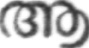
ആ
